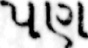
પણ
